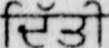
ਦਿੱਤੀ
